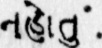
નહોતું.
